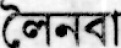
লৈনবা
